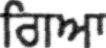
ਗਿਆ
